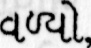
વળ્યો,
